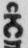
ਨੂੰ
